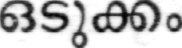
ഒടുക്കം
